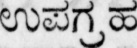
ಉಪಗ್ರಹ
